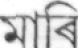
মাৰি
